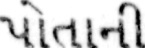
પોતાની
